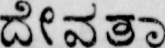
ದೇವತಾ
